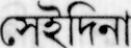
সেইদিনা
